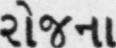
રોજના
